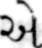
એ
